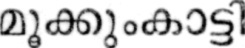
മൂക്കുംകാട്ടി
